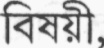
বিষয়ী,
